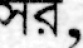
সর,
